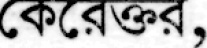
কেরেক্তর,
